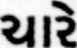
ચારે
